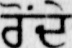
ਰੋਂਦੇ
